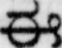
ಈ
